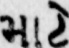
માટે
